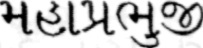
મહાપ્રભુજી
